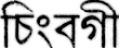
চিংবগী
